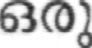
ഒരു
